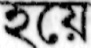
হয়ে
